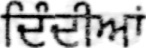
ਦਿੰਦੀਆਂ
